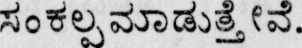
ಸಂಕಲ್ಪಮಾಡುತ್ತೇವೆ.
